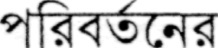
পরিবর্তনের
